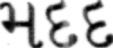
મદદ
